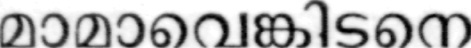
മാമാവെങ്കിടനെ
